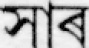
সাৰ
